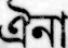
ঐনা
